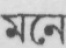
মনে
